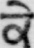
ਕੇ
